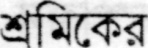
শ্রমিকের
